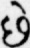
છે
